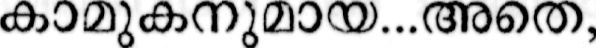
കാമുകനുമായ...അതെ,
